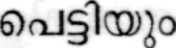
പെട്ടിയും
